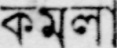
কমলা
